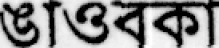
ঙাওবকা
